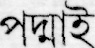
পদ্মাই
